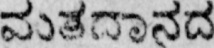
ಮತದಾನದ
